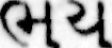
ભય
